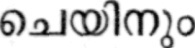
ചെയിനും
